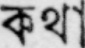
কথা
